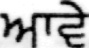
ਆਵੇ
